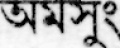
অমসুং
